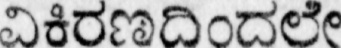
ವಿಕಿರಣದಿಂದಲೇ
